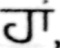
ਹਾਂ,
